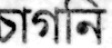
চাগনি
